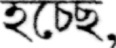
হচ্ছে,
